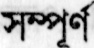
সম্পূর্ণ
